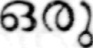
ഒരു
